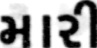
મારી
